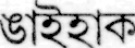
ঙাইহাক
